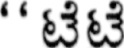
"ಟೆಟೆ
